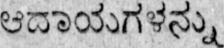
ಆದಾಯಗಳನ್ನು
